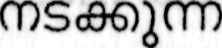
നടക്കുന്ന
